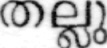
തല്ലു
